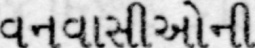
વનવાસીઓની
